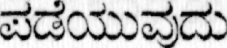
ಪಡೆಯುವುದು
